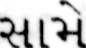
સામે
